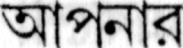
আপনার
